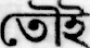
তৌই
